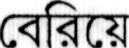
বেরিয়ে
